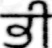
ਭੀ
